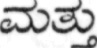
ಮತ್ತು
